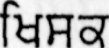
ਖਿਸਕ
